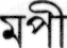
মপী
